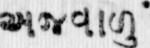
અજવાળું
